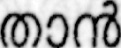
താന്‍
